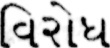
વિરોધ
